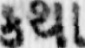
કથા
